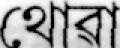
থোৱা
